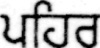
ਪਹਿਰ
